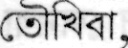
তৌখিবা,
